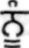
ਨੂੰ
